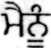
ਮੈਨੂੰ
